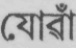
যোৱাঁ
